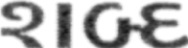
શબ્દ
